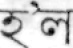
হ'ল
